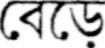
বেড়ে
